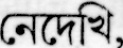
নেদেখি,
